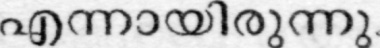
എന്നായിരുന്നു.
